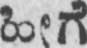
ಹೀಗೆ
